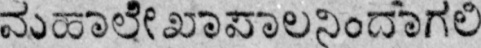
ಮಹಾಲೇಖಾಪಾಲನಿಂದಾಗಲಿ
